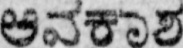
ಅವಕಾಶ
